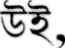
উই,
